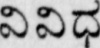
ವಿವಿಧ
